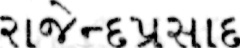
રાજેન્દપ્રસાદ
